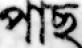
পাছ
